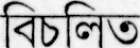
বিচলিত
